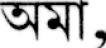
অমা,
